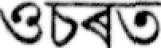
ওচৰত
